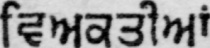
ਵਿਅਕਤੀਆਂ
